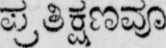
ಪ್ರತಿಕ್ಷಣವೂ
